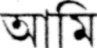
আমি
